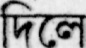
দিলে
